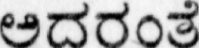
ಅದರಂತೆ
